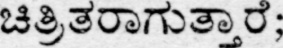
ಚಿತ್ರಿತರಾಗುತ್ತಾರೆ;
